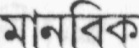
মানবিক
